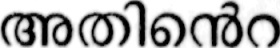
അതിന്റെ
